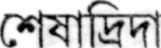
শেষাদ্রিদা
